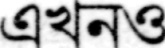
এখনও
